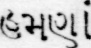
હમણાં
